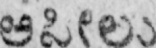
ಅಪೀಲು
